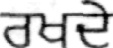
ਰਖਦੇ
